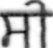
ਸੀ
